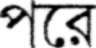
পরে
